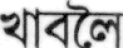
খাবলৈ
